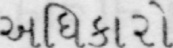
અધિકારો
